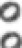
ঃ
